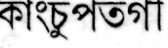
কাংচুপতগী
